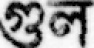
গুল
